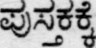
ಪುಸ್ತಕಕ್ಕೆ
